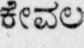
ಕೇವಲ
